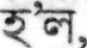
হ'ল,
